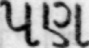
પણ
